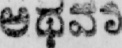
ಅಥವಾ
